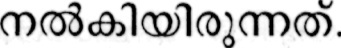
നല്‍കിയിരുന്നത്.
